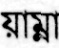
য়াম্না
